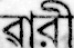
ৱারী
